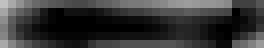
હે
